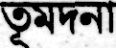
তূমদনা
